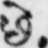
છે.
